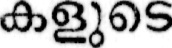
കളുടെ
